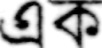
এক
